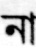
না
